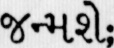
જન્મશે;
